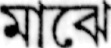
মাঝে
